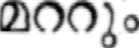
മററും
